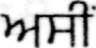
ਅਸੀਂ
